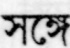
সঙ্গে
